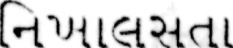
નિખાલસતા
